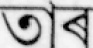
তাৰ
